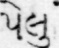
પેલું
